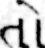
તો
